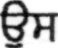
ਉਸ
